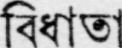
বিধাতা
